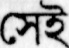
সেই
